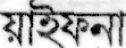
য়াইফনা
